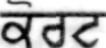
ਕੋਰਟ
